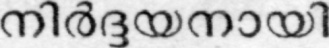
നിര്‍ദ്ദയനായി
